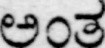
ಅಂತ
